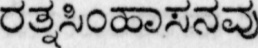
ರತ್ನಸಿಂಹಾಸನವು
